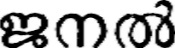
ജനല്‍
